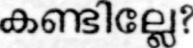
കണ്ടില്ലേ?
